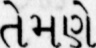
તેમણે
